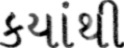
ક્યાંથી
